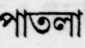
পাতলা
